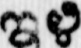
ಇಳಿ
